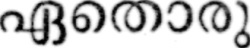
ഏതൊരു
